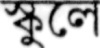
স্কুলে
